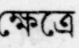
ক্ষেত্রে
